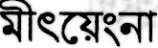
মীৎয়েংনা
